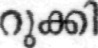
റുക്കി
